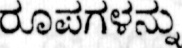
ರೂಪಗಳನ್ನು
